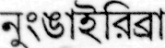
নুংঙাইরিব্রা
